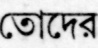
তোদের
